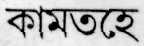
কামতহে
